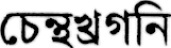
চেন্থখ্রগনি
